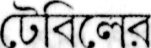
টেবিলের
